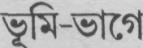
ভূমি-ভাগে
